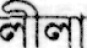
লীলা
